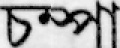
চম্পা
